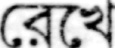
রেখে
